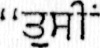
''ਤੁਸੀਂ
